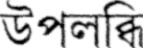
উপলব্ধি
